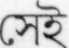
সেই
